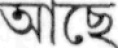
আছে
